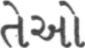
તેઓ
